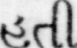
હતી
